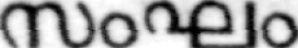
സംഘം
